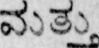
ಮತ್ತು
